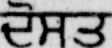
ਦੋਸਤ
